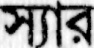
স্যার
